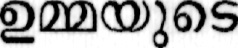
ഉമ്മയുടെ
